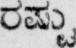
ರಷ್ಟು
